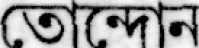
তোন্দোন
